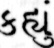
કહ્યું
